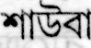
শাউবা
